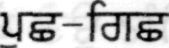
ਪੁਛ-ਗਿਛ
